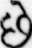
છે
